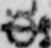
ಈ
